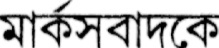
মার্কসবাদকে
